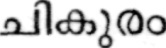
ചികുരം
